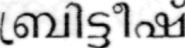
ബ്രിട്ടീഷ്
